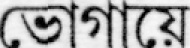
ভোগায়ে
